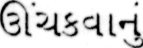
ઊંચકવાનું
